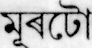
মূৰটো
